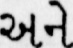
અને
